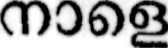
നാളെ
